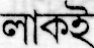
লাকই
